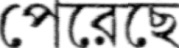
পেরেছে
